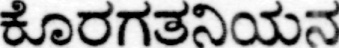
ಕೊರಗತನಿಯನ
